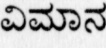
ವಿಮಾನ
